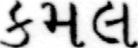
કમલ
